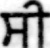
ਸੀ
